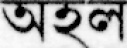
অহল
